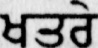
ਖਤਰੇ
